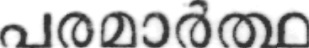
പരമാര്‍ത്ഥ
